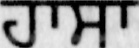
ਹਾਸਾ
